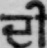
ਦੀ
